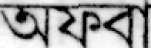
অফবা
